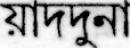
য়াদদুনা
